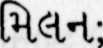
મિલન;
